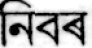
নিবৰ
